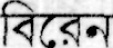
বিরেন
